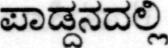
ಪಾಡ್ದನದಲ್ಲಿ
